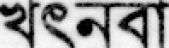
খৎনবা
